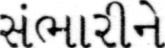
સંભારીને
